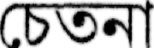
চেতনা
